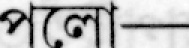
পলো-
